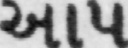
આપ
